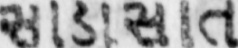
સાડાસાત
